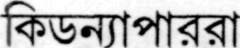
কিডন্যাপাররা
